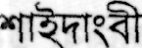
শাইদাংবী
